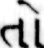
તો
